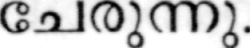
ചേരുന്നു.
